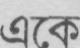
একে
